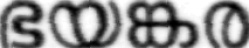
ഭയങ്കര
